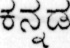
ಕನ್ನಡ
